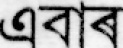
এবাৰ
